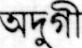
অদুগী
